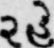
રહે
